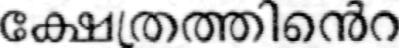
ക്ഷേത്രത്തിന്റെ
